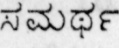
ಸಮರ್ಥ
